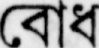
বোধ
